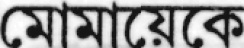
মোমায়েকে
